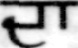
ਦਾ
